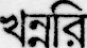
খন্নরি
